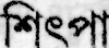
শিৎপা
